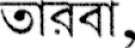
তারবা,
